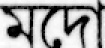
মদো
